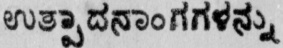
ಉತ್ಪಾದನಾಂಗಗಳನ್ನು
